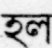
হল
